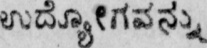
ಉದ್ಯೋಗವನ್ನು
